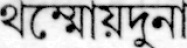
থম্মোয়দুনা
